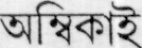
অম্বিকাই
